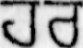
ਹਰ
